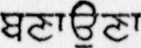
ਬਣਾਉਣਾ
